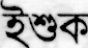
ইশুক
